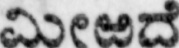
ಮೀಱದೆ
